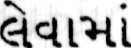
લેવામાં
